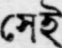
সেই
